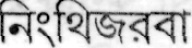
নিংথিজরবা
